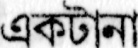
একটানা
